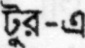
টুর-এ
